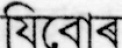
যিবোৰ
